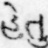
હેતુ
